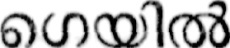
ഗെയില്‍
